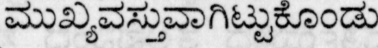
ಮುಖ್ಯವಸ್ತುವಾಗಿಟ್ಟುಕೊಂಡು
